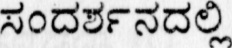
ಸಂದರ್ಶನದಲ್ಲಿ
